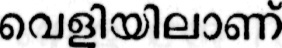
വെളിയിലാണ്
